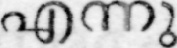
എന്നു
